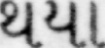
થયા
